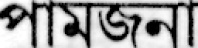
পামজনা
